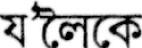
য'লৈকে
